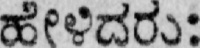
ಹೇಳಿದರು:
